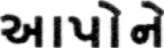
આપોને
